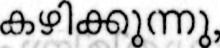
കഴിക്കുന്നു,
